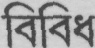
বিবিধ
